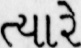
ત્યારે
